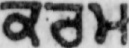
ਕਰਮ
